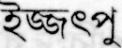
ইজ্জৎপু
